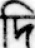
দি
